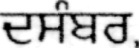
ਦਸੰਬਰ,
